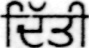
ਦਿੱਤੀ
